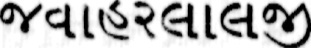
જવાહરલાલજી
